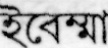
ইবেম্মা
